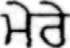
ਮੇਰੇ
